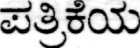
ಪತ್ರಿಕೆಯ
